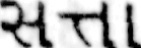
સત્તા
